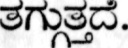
ತಗ್ಗುತ್ತದೆ.
